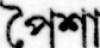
পৈশা
